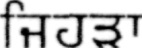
ਜਿਹੜਾ
